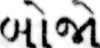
બોજો
